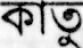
কাতু
